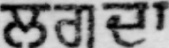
ਲਗਦਾ
